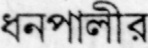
ধনপালীর
